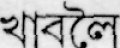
খাবলৈ
